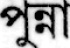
পুন্না
